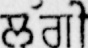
ਲੱਗੀ
